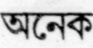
অনেক
